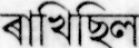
ৰাখিছিল
